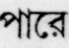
পারে
